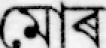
মোৰ
